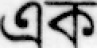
এক
